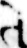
તે
